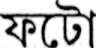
ফটো
